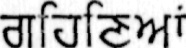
ਗਹਿਣਿਆਂ
